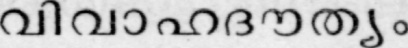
വിവാഹദൌത്യം
